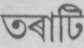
তৰাটি
